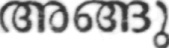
അങ്ങു
